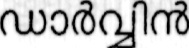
ഡാര്‍വ്വിന്‍
